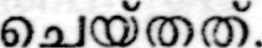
ചെയ്തത്.
